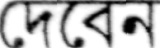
দেবেন
